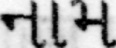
નામ
